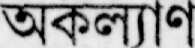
অকল্যাণ
